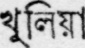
খুলিয়া
